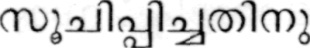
സൂചിപ്പിച്ചതിനു
